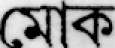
মোক
